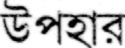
উপহার
